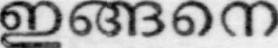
ഇങ്ങനെ
